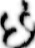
છ
